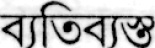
ব্যতিব্যস্ত
